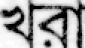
খরা
